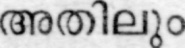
അതിലും
